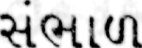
સંભાળ
